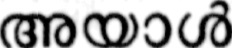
അയാള്‍
